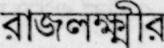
রাজলক্ষ্মীর
